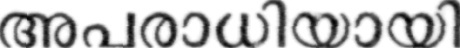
അപരാധിയായി
